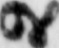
જ
